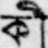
কী
